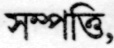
সম্পত্তি,
